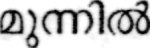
മുന്നില്‍
